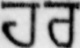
ਹਰ
